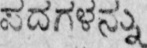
ಪದಗಳನ್ನು
